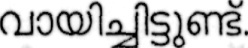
വായിച്ചിട്ടുണ്ട്.
